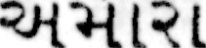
અમારા
